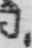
ਹੈ,
